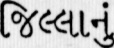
જિલ્લાનું
